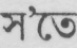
স'তে
